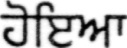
ਹੋਇਆ
